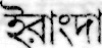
ইরাংদা
